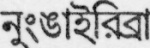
নুংঙাইরিব্রা
